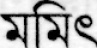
মমিৎ
